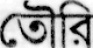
তৌরি
